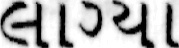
લાગ્યા
